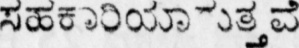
ಸಹಕಾರಿಯಾಗುತ್ತವೆ.
